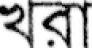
খরা
